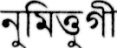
নুমিত্তুগী
